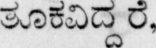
ತೂಕವಿದ್ದರೆ,
